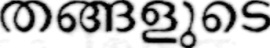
തങ്ങളുടെ
